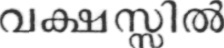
വക്ഷസ്സില്‍
